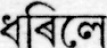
ধৰিলে
